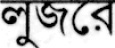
লুজরে
